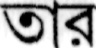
তার
